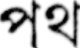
পথ
